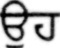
ਉਹ
